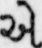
એ
